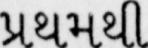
પ્રથમથી
